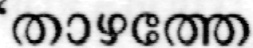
‘താഴത്തേ
